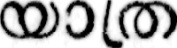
യാത്ര
